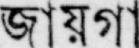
জায়গা
